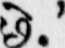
છે.'
